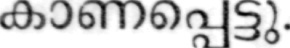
കാണപ്പെട്ടു.
